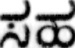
ಸಹ
